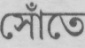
সোঁতে
